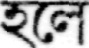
হলে
